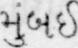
મુંબઈ
